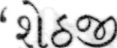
'શેઠજી
